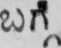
ಬಗ್ಗೆ
